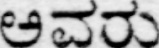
ಅವರು
